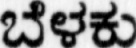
ಬೆಳಕು
